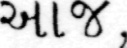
આજ,
